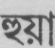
হুয়া
